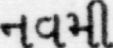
નવમી
